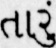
તારું
